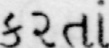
કરતાં
